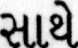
સાથે
